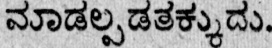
ಮಾಡಲ್ಪಡತಕ್ಕುದು.
